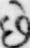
છે
